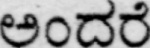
ಅ೦ದರೆ
